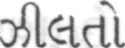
ઝીલતો
